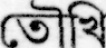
তৌখি
